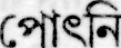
পোৎনি
